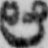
ಆ
